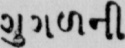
ગુગળની
